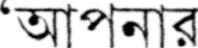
‘আপনার
